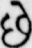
છે
